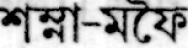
শম্না-মফৈ
